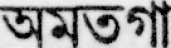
অমতগা
